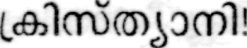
ക്രിസ്ത്യാനി!
